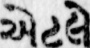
એટલે
